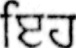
ਇਹ
